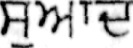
ਸੁਆਦ
